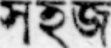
সহজ
